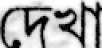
দেখা
